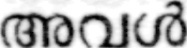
അവള്‍
